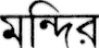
মন্দির
